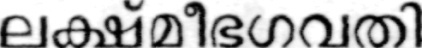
ലക്ഷ്മീഭഗവതി
